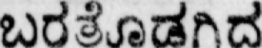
ಬರತೊಡಗಿದ
